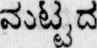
ಮಟ್ಟದ
